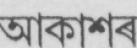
আকাশৰ
